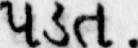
પડત.
